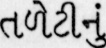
તળેટીનું
